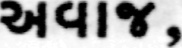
અવાજ,
